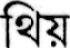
থিয়
